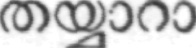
തയ്യാറാ
